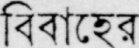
বিবাহের
